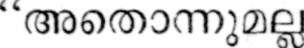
"അതൊന്നുമല്ല
